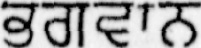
ਭਗਵਾਨ
